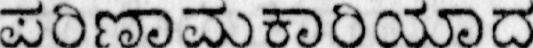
ಪರಿಣಾಮಕಾರಿಯಾದ
